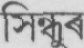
সিন্ধুৰ
